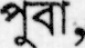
পুবা,
